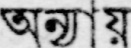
অন্যায়
